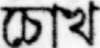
চোখ
